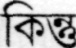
কিন্তু
